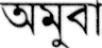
অমুবা
